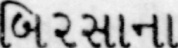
બિરસાના
